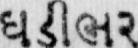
ઘડીભર
